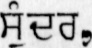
ਸੁੰਦਰ,
